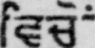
ਵਿਚੋਂ
